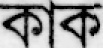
কাক
